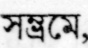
সম্ভ্রমে,
